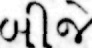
બીજે
